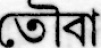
তৌবা
